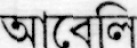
আবেলি
